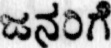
ಜನರಿಗೆ
